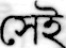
সেই
